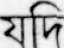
যদি
